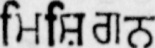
ਮਿਸ਼ਿਗਨ
